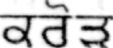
ਕਰੋੜ
